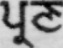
ਪ੍ਰਣ
